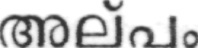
അല്പം
